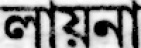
লায়না
